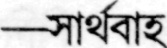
–সার্থবাহ
